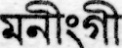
মনীংগী
